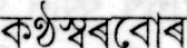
কণ্ঠস্বৰবোৰ
